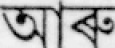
আৰু
